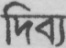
দিব্য
